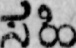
ಸಹಿ
